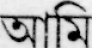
আমি
